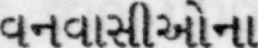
વનવાસીઓના
